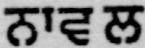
ਨਾਵਲ
